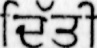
ਦਿੱਤੀ
